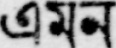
এমন
